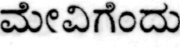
ಮೇವಿಗೆಂದು
